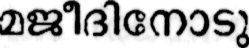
മജീദിനോടു
